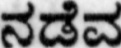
ನಡೆವ
